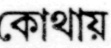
কোথায়
